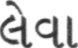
લેવા
